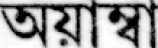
অয়াম্বা
